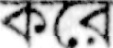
করে
